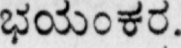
ಭಯಂಕರ.
